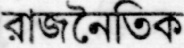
রাজনৈতিক
